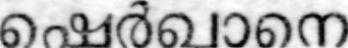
ഷെര്‍ഖാനെ
